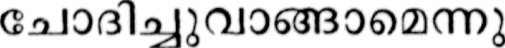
ചോദിച്ചുവാങ്ങാമെന്നു
